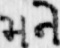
મને
